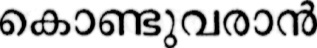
കൊണ്ടുവരാന്‍
